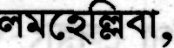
লমহেল্লিবা,
